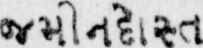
જમીન
